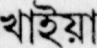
খাইয়া
